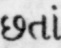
છતાં
